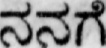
ನನಗೆ
